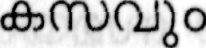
കസവും
